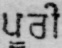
ਪੂਰੀ
